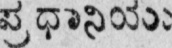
ಪ್ರಧಾನಿಯು
